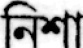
নিশা
